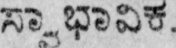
ಸ್ವಾಭಾವಿಕ.
